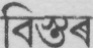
বিস্তৰ
